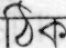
ঠিক
